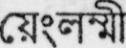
য়েংলম্মী
